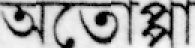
অতোপ্পা
